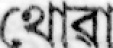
থোৱা
